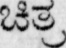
ಚಿತ್ರ
